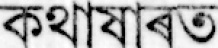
কথাষাৰত
